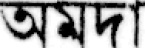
অমদা
